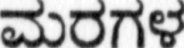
ಮರಗಳ
